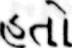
હતો
